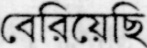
বেরিয়েছি
